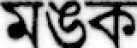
মঙক
